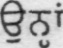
ਉਨ੍ਹਾਂ
